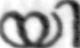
യി
